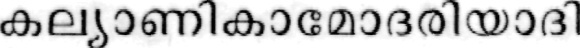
കല്യാണികാമോദരിയാദി
